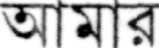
আমার
